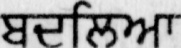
ਬਦਲਿਆ
